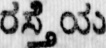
ರಸ್ತೆಯ
